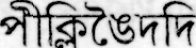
পীক্লি্ঙৈদদি
